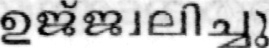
ഉജ്ജ്വലിച്ചു
